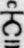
ਨੂੰ
